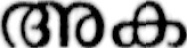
അക
